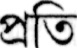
প্রতি
